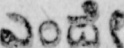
ಎಂದೇ
